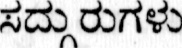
ಸದ್ಗುರುಗಳು
